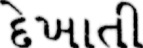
દેખાતી
